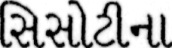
સિસોટીના
